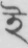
ই
